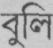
বুলি
